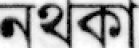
নথকা
